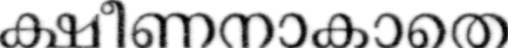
ക്ഷീണനാകാതെ
